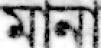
মানা
